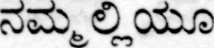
ನಮ್ಮಲ್ಲಿಯೂ
